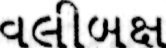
વલીબક્ષ
